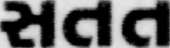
સતત
